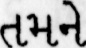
તમને
